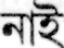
নাই
